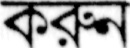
করুন
